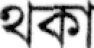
থকা
